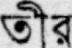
তীর
